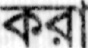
করা
